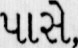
પાસે,
